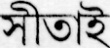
সীতাই
